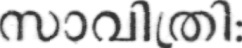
സാവിത്രി:
